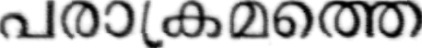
പരാക്രമത്തെ
